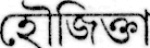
হৌজিক্তা
